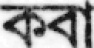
কবা
